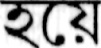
হয়ে
